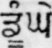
ਡੂੰਘੇ
